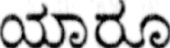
ಯಾರೂ
